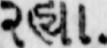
રહ્યા.
